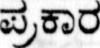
ಪ್ರಕಾರ
